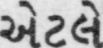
એટલે
